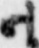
ન
